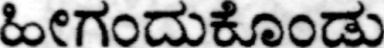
ಹೀಗಂದುಕೊಂಡು
